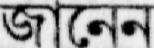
জানেন
